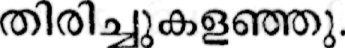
തിരിച്ചുകളഞ്ഞു.
